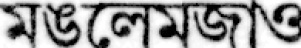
মঙলেমজাও
